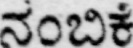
ನಂಬಿಕೆ
